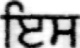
ਇਸ
